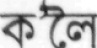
ক'লৈ
